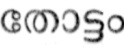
തോട്ടം
